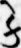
કે
